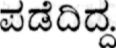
ಪಡೆದಿದ್ದ.
